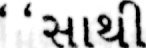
"સાથી
